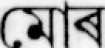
মোৰ
